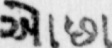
ઓછા
